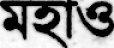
মহাও
